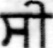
ਸੀ
